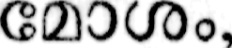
മോശം,
